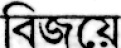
বিজয়ে
